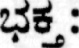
ಭಕ್ತ:
